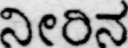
ನೀರಿನ
